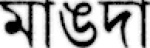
মাঙদা
